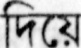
দিয়ে
